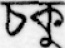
চকু
